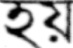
হয়
